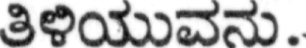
ತಿಳಿಯುವನು.
